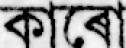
কাৰো
